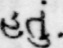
હતું.
